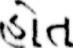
હોત
